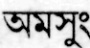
অমসুং
